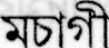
মচাগী
